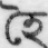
হৈ
